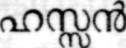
ഹസ്സന്‍
